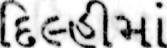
દિલ્હીમાં
